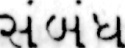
સબંધ
